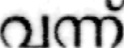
വന്ന്
